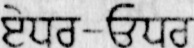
ਏਧਰ-ਓਧਰ
